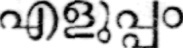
എളുപ്പം
